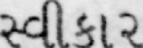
સ્વીકાર
